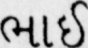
ભાઈ
